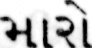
મારો
